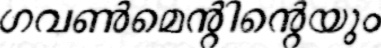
ഗവണ്‍മെന്റിന്റെയും
